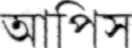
আপিস
